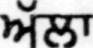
ਅੱਲਾ
